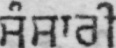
ਸੰਸਾਰੀ
